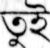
তুই
